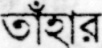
তাঁহার
